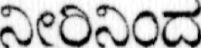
ನೀರಿನಿಂದ
